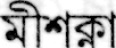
মীশক্না
